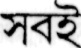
সবই
